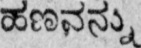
ಹಣವನ್ನು
